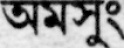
অমসুং
